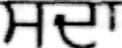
ਸਦਾ
